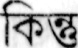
কিন্তু
